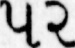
પર
